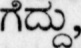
ಗೆದ್ದು,
